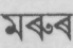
মৰুৰ
